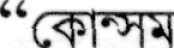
“কোন্সম
